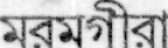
মরমগীরা
